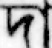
দা
